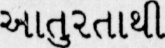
આતુરતાથી
